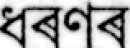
ধৰণৰ
